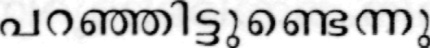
പറഞ്ഞിട്ടുണ്ടെന്നു
